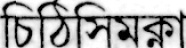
চিঠিসিমক্না
